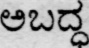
ಅಬದ್ಧ
